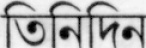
তিনিদিন
